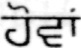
ਹੋਵਾਂ
